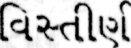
વિસ્તીર્ણ
